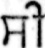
ਸੀ
